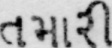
તમારી
